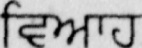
ਵਿਆਹ
